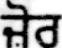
ਜ਼ੋਰ
